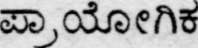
ಪ್ರಾಯೋಗಿಕ
